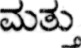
ಮತ್ತು
